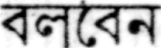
বলবেন
